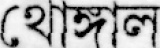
থোঙ্গাল
